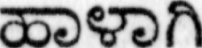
ಹಾಳಾಗಿ
